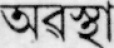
অৱস্থা
